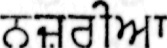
ਨਜ਼ਰੀਆ
